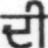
ਦੀ
